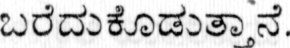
ಬರೆದುಕೊಡುತ್ತಾನೆ.
